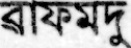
ৱাফমদু
